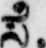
ಸೆ.
